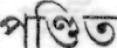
পণ্ডিত
